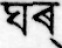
ঘৰ্
